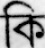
কি
